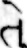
તે
